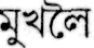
মুখলৈ
